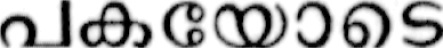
പകയോടെ
